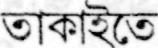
তাকাইতে
